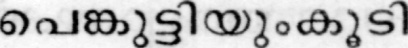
പെങ്കുട്ടിയുംകൂടി
